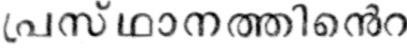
പ്രസ്ഥാനത്തിന്റെ
